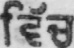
ਵਿੱਚ
